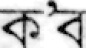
ক'ব
